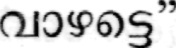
വാഴട്ടെ"
